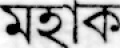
মহাক
